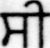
ਸੀ
